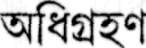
অধিগ্রহণ
